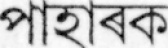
পাহাৰক
